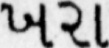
ખરા
